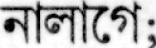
নালাগে;
